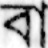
বা
